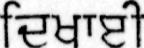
ਦਿਖਾਈ
